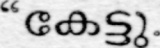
"കേട്ടു.
